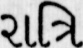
રાત્રિ
